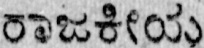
ರಾಜಕೀಯ
